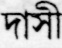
দাসী
